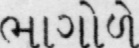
ભાગોળે
